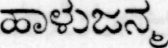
ಹಾಳುಜನ್ಮ
